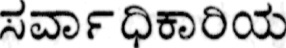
ಸರ್ವಾಧಿಕಾರಿಯ
